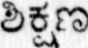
ಶಿಕ್ಷಣ
